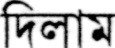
দিলাম
